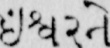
ઈશ્વરને
